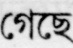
গেছে
